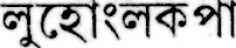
লুহোংলকপা
